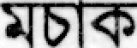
মচাক
